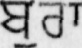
ਬੁਰਾ
